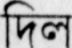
দিল
